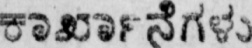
ಕಾರ್ಖಾನೆಗಳು
